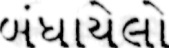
બંધાયેલો
